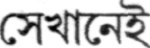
সেখানেই
